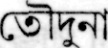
তৌদুনা
